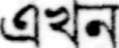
এখন
